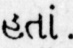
હતાં.
